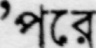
’পরে
